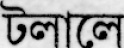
টলালে
